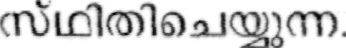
സ്ഥിതിചെയ്യുന്ന.
